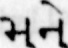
મને
